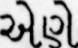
એણે
